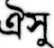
ঐসু
